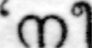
‘നീ
